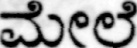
ಮೇಲೆ
